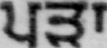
ਪੜਾ
